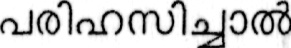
പരിഹസിച്ചാല്‍
